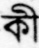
কী
